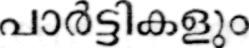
പാര്‍ട്ടികളും
